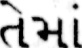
તેમાં
